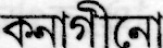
কনাগীনো
